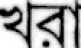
খরা
